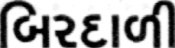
બિરદાળી
